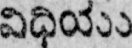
ವಿಧಿಯು
